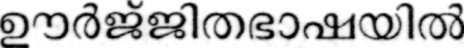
ഊര്‍ജ്ജിതഭാഷയില്‍
